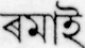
ৰমাই
